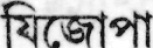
যিজোপা
